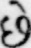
છે
